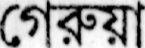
গেরুয়া
